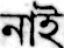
নাই
